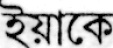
ইয়াকে
